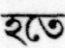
হতে
